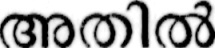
അതില്‍
